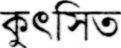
কুত্সিত
